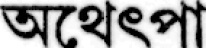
অথেৎপা
